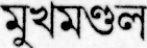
মুখমণ্ডল
